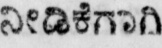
ನೀಡಿಕೆಗಾಗಿ
